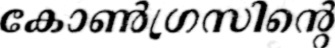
കോണ്‍ഗ്രസിന്റെ
